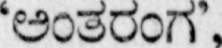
‘ಅಂತರಂಗ’,
